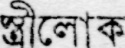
স্ত্রীলোক
